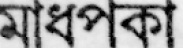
মাধপকা
